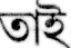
তাই
